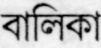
বালিকা
